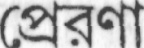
প্রেরণা
